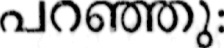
പറഞ്ഞു:
